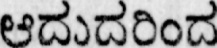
ಆದುದರಿಂದ
